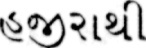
હજીરાથી
